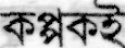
কপ্পকই
